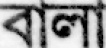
বালা
